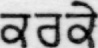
ਕਰਕੇ
